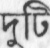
দুটি
